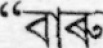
"বাৰু
